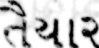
તૈયાર
